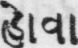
હોવા
